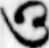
ও
